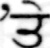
'ਤੇ
